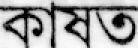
কাষত
